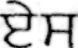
ਏਸ
